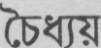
চৈধ্যয়
